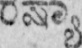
ರಷ್ಯಾ
